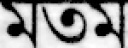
মতম
